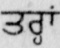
ਤਰ੍ਹਾਂ
